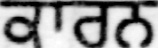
ਕਾਰਨ
